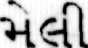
મેલી
